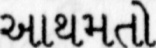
આથમતો
